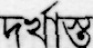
দর্খাস্ত
